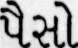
પૈસો
